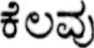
ಕೆಲವು
